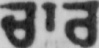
ਚਾਰ
